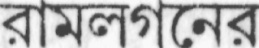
রামলগনের
